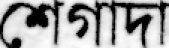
শেগাদা
